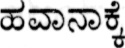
ಹವಾನಾಕ್ಕೆ
